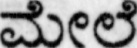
ಮೇಲೆ
